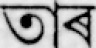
তাৰ
